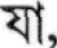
যা,
